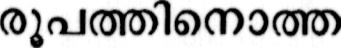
രൂപത്തിനൊത്ത
